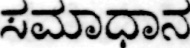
ಸಮಾಧಾನ
